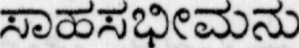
ಸಾಹಸಭೀಮನು
